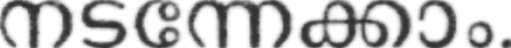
നടന്നേക്കാം.
